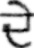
ਦੇ
